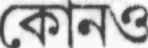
কোনও
